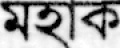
মহাক
